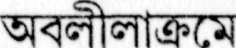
অবলীলাক্রমে
